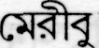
মেরীবু
